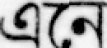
এনে
